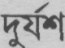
দুর্যশ
